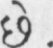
છે.
